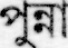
পু্ন্না
